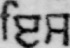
ਇਸ
